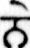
ਨੇ
